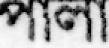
পালা
